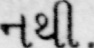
નથી.
